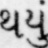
થયું
